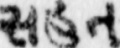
સહન
